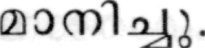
മാനിച്ചു.
